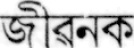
জীৱনক
